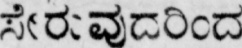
ಸೇರುವುದರಿಂದ
